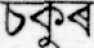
চকুৰ
